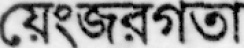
য়েংজরগতা
